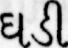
ઘડી
